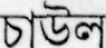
চাউল
